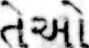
તેઓ
